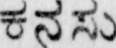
ಕನಸು
